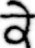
ਕੇ
